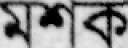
মশক
